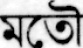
মতৌ
